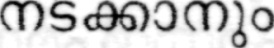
നടക്കാനും
